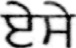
ਏਸੇ
